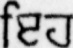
ਇਹ
